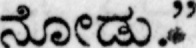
ನೋಡು.”
